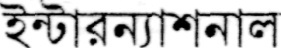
ইন্টারন্যাশনাল
